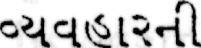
વ્યવહારની
